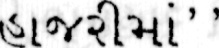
હાજરીમાં"
